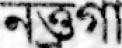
নও্রগা
